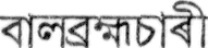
বালব্রহ্মচাৰী
